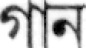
গান
